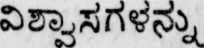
ವಿಶ್ವಾಸಗಳನ್ನು
